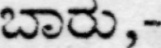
ಬಾರು, -
